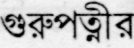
গুরুপত্নীর
